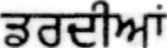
ਡਰਦੀਆਂ
